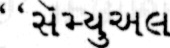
"સૅમ્યુઆર
